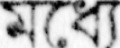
মধ্যে
